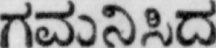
ಗಮನಿಸಿದ
